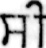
ਸੀ
